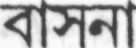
বাসনা
